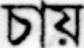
চায়
